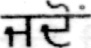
ਜਦੋਂ
